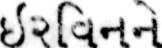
ઇરવિનને
